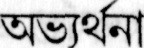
অভ্যর্থনা
